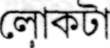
লোকটা
